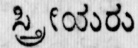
ಸ್ತ್ರೀಯರು
